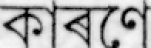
কাৰণে
